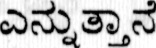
ಎನ್ನುತ್ತಾನೆ
